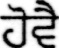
ਹੋਵੈ
